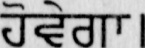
ਹੋਵੇਗਾ।
